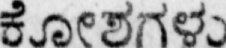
ಕೋಶಗಳು
